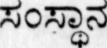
ಸಂಸ್ಥಾನ
